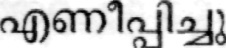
എണീപ്പിച്ചു
